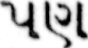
પણ
